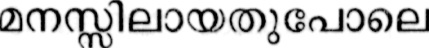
മനസ്സിലായതുപോലെ
